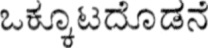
ಒಕ್ಕೂಟದೊಡನೆ
